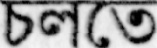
চলতে
